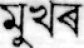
মুখৰ
